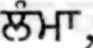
ਲੰਮਾ,
